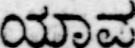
ಯಾವ
